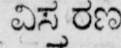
ವಿಸ್ತರಣ
